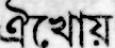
ঐখোয়
